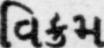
વિક્રમ
